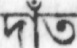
দাঁত
